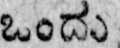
ಒಂದು
